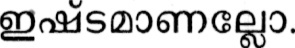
ഇഷ്ടമാണല്ലോ.
